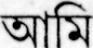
আমি
